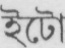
ইটো
